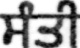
ਸੰਤੀ
